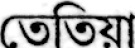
তেতিয়া
